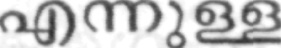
എന്നുള്ള
